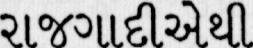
રાજગાદીએથી
